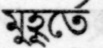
মুহূর্তে
